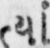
ત્યાં
